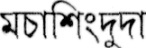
মচাশিংদুদা
